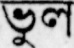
ভুল
